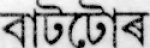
বাটটোৰ
